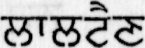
ਲਾਲਟੈਣ
